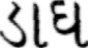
ડાઘ
